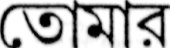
তোমার
